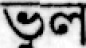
ভুল
